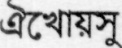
ঐখোয়সু
